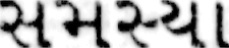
સમસ્યા
